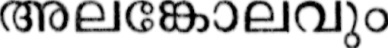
അലങ്കോലവും
